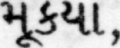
મૂક્યા,
